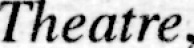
Theatre,
